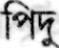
পিদু
